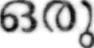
ഒരു
